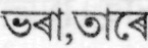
ভৰা,তাৰে
